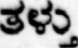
ತಳ್ತು
